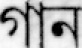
গান
